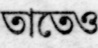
তাতেও
